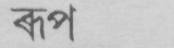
ৰূপ
